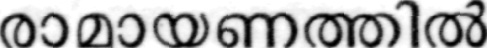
രാമായണത്തില്‍
